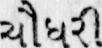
ચૌધરી
